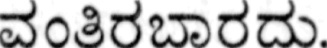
ವಂತಿರಬಾರದು.
